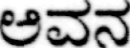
ಅವನ
